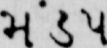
મંડપ
